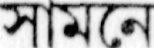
সামনে
